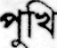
পুখি
